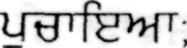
ਪੁਚਾਇਆ;
